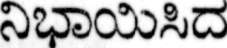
ನಿಭಾಯಿಸಿದೆ
